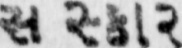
સંસ્કાર
